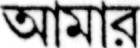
আমার
